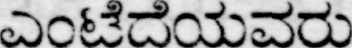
ಎಂಟೆದೆಯವರು
